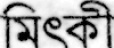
মিৎকী
